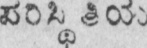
ಪರಿಸ್ಥಿತಿಯ
